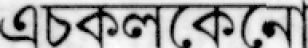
এচকলকেনো
